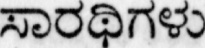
ಸಾರಥಿಗಳು
